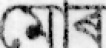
মোৰ
